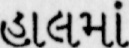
હાલમાં
